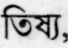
তিষ্য,
